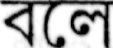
বলে
